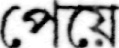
পেয়ে
